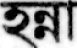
হন্না
